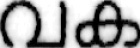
വക
